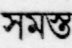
সমস্ত
